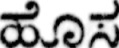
ಹೊಸ
